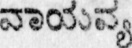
ವಾಯವ್ಯ
